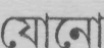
যোনো
